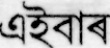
এইবাৰ
